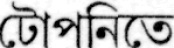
টোপনিতে
